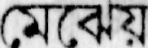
মেঝেয়
